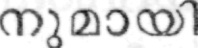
നുമായി
